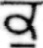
ਕੁ
